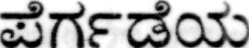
ಪೆರ್ಗಡೆಯ
